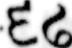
દૃઢ
